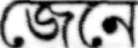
জেনে
